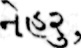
નેહરુ,
